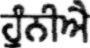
ਹੁੰਨੀਐ
